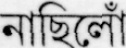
নাছিলোঁ
